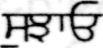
ਸੁਝਾਓ
